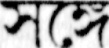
সঙ্গে
